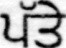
ਪੱਤੇ
